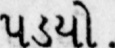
પડ્યો.
